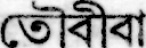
তৌবীবা
